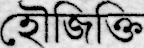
হৌজিক্তি
